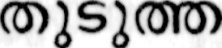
തുടുത്ത
